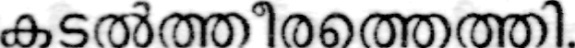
കടല്‍ത്തീരത്തെത്തി.
